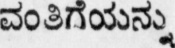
ವಂತಿಗೆಯನ್ನು
